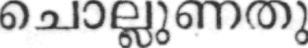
ചൊല്ലുണതു
